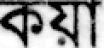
কয়া
